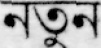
নতুন
